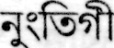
নুংতিগী
